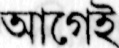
আগেই
